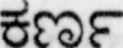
ಕರ್ಣ
